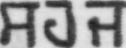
ਸਹਜ
